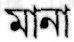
মানা
